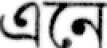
এনে
